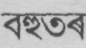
বহুতৰ
